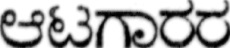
ಆಟಗಾರರ
